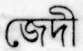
জেদী
